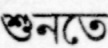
শুনতে
